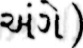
અંગે)
